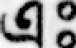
এঃ
